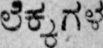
ಲೆಕ್ಕಗಳ
